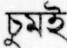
চুমই
